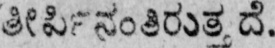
ತೀರ್ಪಿನಂತಿರುತ್ತದೆ.
